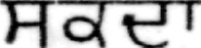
ਸਕਦਾ
